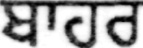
ਬਾਹਰ
